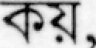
কয়,
